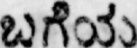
ಬಗೆಯ
